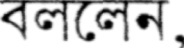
বললেন,
